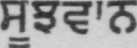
ਸੂਝਵਾਨ
